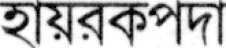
হায়রকপদা
